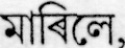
মাৰিলে,
